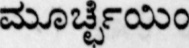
ಮೂರ್ಚ್ಛೆಯಿಂ
